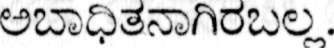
ಅಬಾಧಿತನಾಗಿರಬಲ್ಲ.
